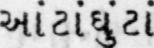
આંટાંઘુંટાં
